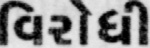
વિરોધી
